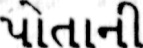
પોતાની
